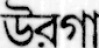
উরগা
